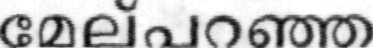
മേല്പറഞ്ഞ
